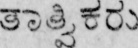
ತಾತ್ವಿಕರು
